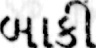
બાકી
